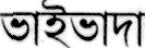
ভাইভাদা
